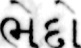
ભેદો
